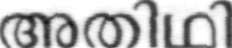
അതിഥി
